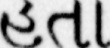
હતા
